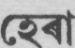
হেৰা
